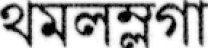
থমলম্লগা
